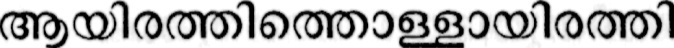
ആയിരത്തിത്തൊള്ളായിരത്തി
